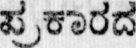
ಪ್ರಕಾರದ
